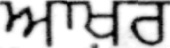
ਆਖ਼ਰ
